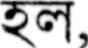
হল,
